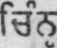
ਚਿੰਨ੍ਹ
